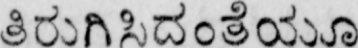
ತಿರುಗಿಸಿದಂತೆಯೂ
